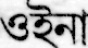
ওইনা
